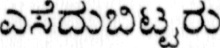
ಎಸೆದುಬಿಟ್ಟರು
